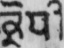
ਕ੍ਰੋਧੀ
